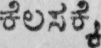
ಕೆಲಸಕ್ಕೆ
